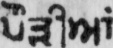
ਪੌੜੀਆਂ
